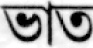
ভাত
